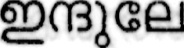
ഇന്ദുലേ
